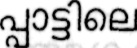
പ്പാട്ടിലെ
